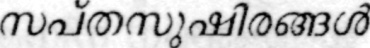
സപ്തസുഷിരങ്ങള്‍
